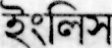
ইংলিস
